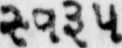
સ્વરૂપ
